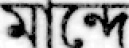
মান্দে
